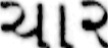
ચાર
